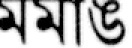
মমাঙ
